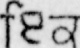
ਇਕ
